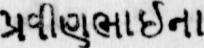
પ્રવીણભાઈના
